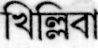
খিল্লিবা
